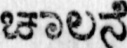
ಚಾಲನೆ
